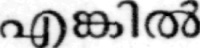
എങ്കില്‍
